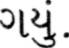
ગયું.
